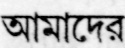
আমাদের
